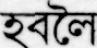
হবলৈ
